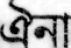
ঐনা
